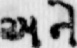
અને
